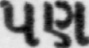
પણ
